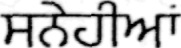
ਸਨੇਹੀਆਂ
